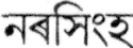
নৰসিংহ
